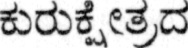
ಕುರುಕ್ಷೇತ್ರದ
